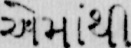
એમાંથી
